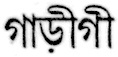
গাড়ীগী
